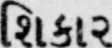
શિકાર
